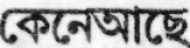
কেনেআছে
